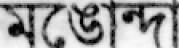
মঙোন্দা
